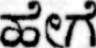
ಹೇಗೆ
